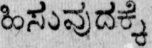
ಹಿಸೆವುದಕ್ಕೆ
